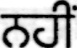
ਨਹੀਂ
